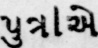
પુત્રીએ
